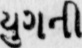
યુગની
